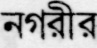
নগরীর
